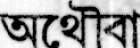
অথৌবা
